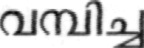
വമ്പിച്ച
